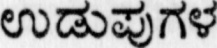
ಉಡುಪುಗಳ
